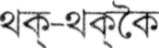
থক্‌-থক্‌কৈ
